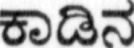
ಕಾಡಿನ
